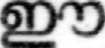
ഈ
